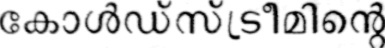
കോള്‍ഡ്സ്ട്രീമിന്റെ
